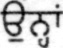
ਉਨ੍ਹਾਂ
